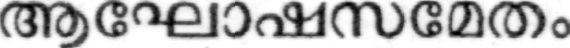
ആഘോഷസമേതം
